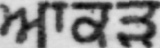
ਆਕੜ
